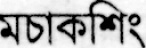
মচাকশিং
